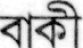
বাকী
